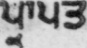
ਪ੍ਰਾਪਤ
